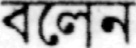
বলেন
